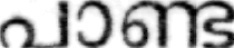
പാണ്ട
